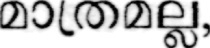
മാത്രമല്ല,
